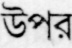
উপর
